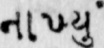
નાખ્યું
